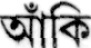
আঁকি
